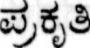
ಪ್ರಕೃತಿ
